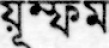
য়ূম্ফম
